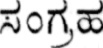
ಸಂಗ್ರಹ
